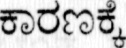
ಕಾರಣಕ್ಕೆ
